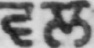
ਵਲ
